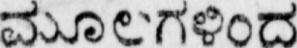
ಮೂಲಗಳಿಂದ
